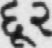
દૂર
